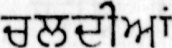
ਚਲਦੀਆਂ
